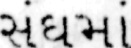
સંઘમાં
